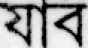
যাব
